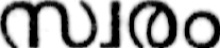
സ്വരം
